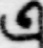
এ
